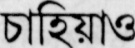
চাহিয়াও
